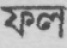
ফল
